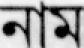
নাম
